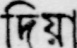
দিয়া
